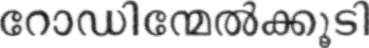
റോഡിന്മേല്‍ക്കൂടി
